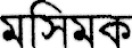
মসিমক
